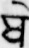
ਬੇ
